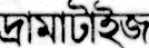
দ্রামাটাইজ
